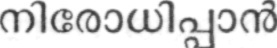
നിരോധിപ്പാന്‍
